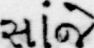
સાંજે
